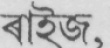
ৰাইজ,
